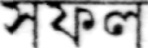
সফল
